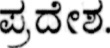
ಪ್ರದೇಶ.
